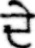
ਦੇ
